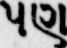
પણ
